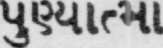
પુણ્યાત્મા
